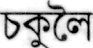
চকুলৈ
